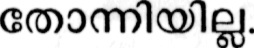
തോന്നിയില്ല.
